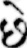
છે
